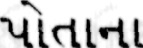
પોતાના
